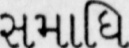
સમાધિ
